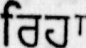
ਰਿਹਾ
